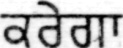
ਕਰੇਗਾ
